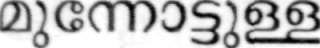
മുന്നോട്ടുള്ള
